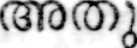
അതു
